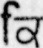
ਕਿ
